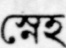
স্নেহ
